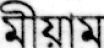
মীয়াম
